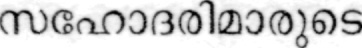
സഹോദരിമാരുടെ
